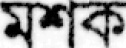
মশক
